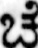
ಚೆ
